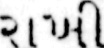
રાખી
